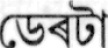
ডেৰটা
